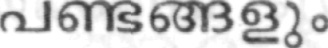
പണ്ടങ്ങളും
